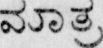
ಮಾತ್ರ
